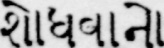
શોધવાનો
